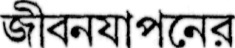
জীবনযাপনের
